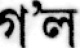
গ'ল
